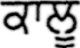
ਕਾਲੂ
